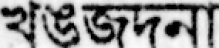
খঙজদনা
